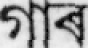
গাৰ
